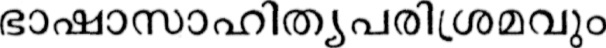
ഭാഷാസാഹിത്യപരിശ്രമവും
